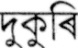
দুকুৰি
